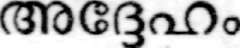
അദ്ദേഹം
